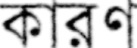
কারণ
